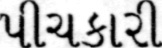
પીચકારી
